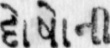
દોષોની
